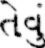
તેવું
